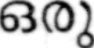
ഒരു
